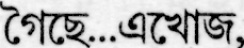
গৈছে...এখোজ,
